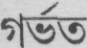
গৰ্ভত
